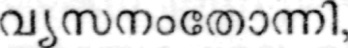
വ്യസനംതോന്നി,
